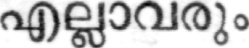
എല്ലാവരും
